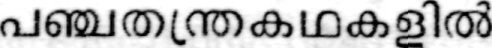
പഞ്ചതന്ത്രകഥകളില്‍
